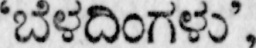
‘ಬೆಳದಿಂಗಳು’,
